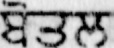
ਬੋਤਲ
